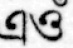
এওঁ
